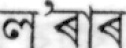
ল'ৰাৰ
